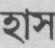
হাস
